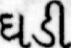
ઘડી
